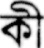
কী
